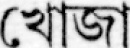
খোজা
